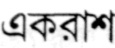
একরাশ
